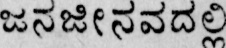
ಜನಜೀವನದಲ್ಲಿ
